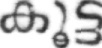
കൂട്ട
